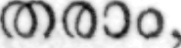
തരാം,
